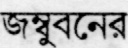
জম্বুবনের
